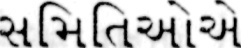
સમિતિઓએ
